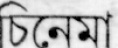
চিনেমা
